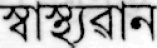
স্বাস্হ্যৱান
